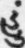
હું
